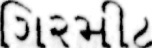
ગિરમીટ
